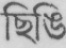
ছিঙি
